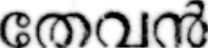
തേവന്‍
